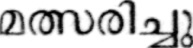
മത്സരിച്ചു
